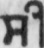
ਸੀ
